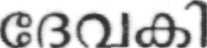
ദേവകി
